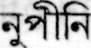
নুপীনি
